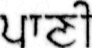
ਪਾਣੀ
